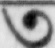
ত
